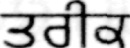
ਤਰੀਕ
